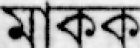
মাকক
